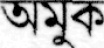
অমুক
